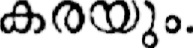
കരയും.
